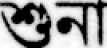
শুনা
